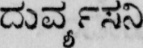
ದುರ್ವ್ಯಸನಿ
